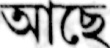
আছে
